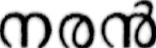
നരന്‍
